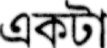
একটা
